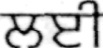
ਲਈ
